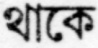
থাকে
